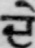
ਦੇ
